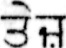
ਤੇਜ਼
